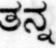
ತನ್ನ
